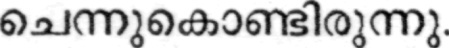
ചെന്നുകൊണ്ടിരുന്നു.
